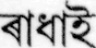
ৰাধাই
